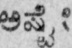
ಅಷ್ಟೇ
